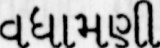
વધામણી
